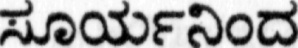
ಸೂರ್ಯನಿಂದ
